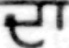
ਦਾ
